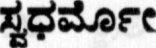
ಸ್ವಧರ್ಮೋ
